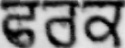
ਫਰਕ
